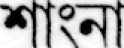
শাংনা
